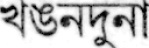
খঙনদুনা
